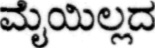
ಮೈಯಿಲ್ಲದ
